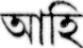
আহি
